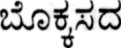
ಬೊಕ್ಕಸದ
